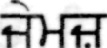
ਜੇਮਜ਼
